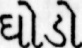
ઘોડો
